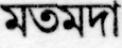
মতমদা
